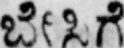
ಬೇಸಿಗೆ
